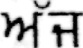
ਅੱਜ
